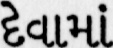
દેવામાં
